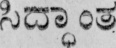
ಸಿದ್ದಾಂತ
